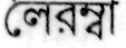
লৈরম্বা
